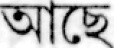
আছে
